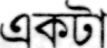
একটা
